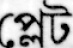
প্লেট
